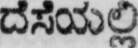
ದೆಸೆಯಲ್ಲಿ
